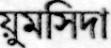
য়ুমসিদা
